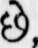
છે,
